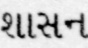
શાસન
